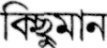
কিছুমান
